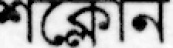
শক্লোন
